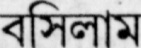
বসিলাম
